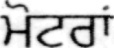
ਮੋਟਰਾਂ
